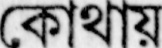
কোথায়
